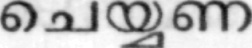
ചെയ്യണ
